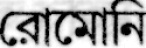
রোমোনি
